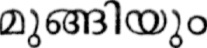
മുങ്ങിയും
